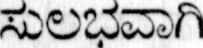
ಸುಲಭವಾಗಿ
